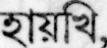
হায়খি,
